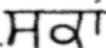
ਸਕਾਂ
